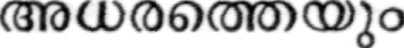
അധരത്തെയും
